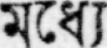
মধ্যে
